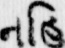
નહિ
